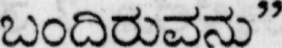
ಬಂದಿರುವನು”
